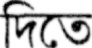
দিতে
